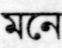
মনে
